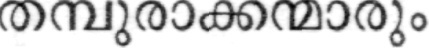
തമ്പുരാക്കന്മാരും
